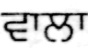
ਵਾਲਾ
